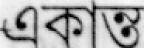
একান্ত
